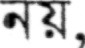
নয়,
